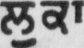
ਲੁਕਾ
